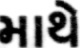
માથે
